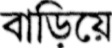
বাড়িয়ে
